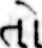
તો
